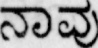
ನಾವು
